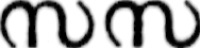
സസ
